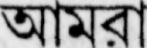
আমরা
